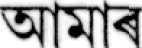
আমাৰ
